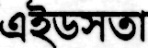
এইডসতা
